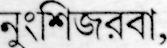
নুংশিজরবা,
